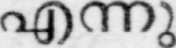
എന്നു
